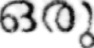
ഒരു
